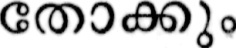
തോക്കും
